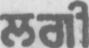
ਲਗੀ
